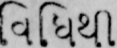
વિધિથી
